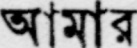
আমার
